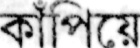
কাঁপিয়ে
